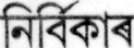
নির্বিকাৰ
